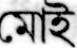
মোই
